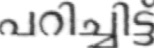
പറിച്ചിട്ട്
